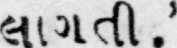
લાગતી.'
